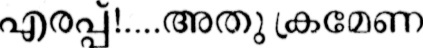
എരപ്പ്!....അതുക്രമേണ
